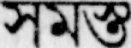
সমস্ত
